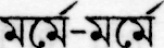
মর্মে-মর্মে
